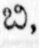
ಬಿ,
